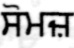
ਸੋਮਜ਼
